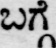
ಬಗ್ಗೆ
